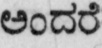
ಅಂದರೆ
